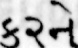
કરને
